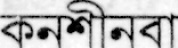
কনশীনবা
